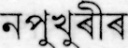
নপুখুৰীৰ
